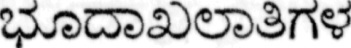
ಭೂದಾಖಲಾತಿಗಳ
